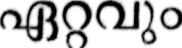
ഏറ്റവും
